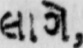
લાગે,
